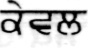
ਕੇਵਲ
